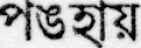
পঙহায়
